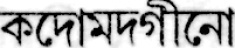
কদোমদগীনো
